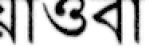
য়াওবা
